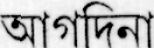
আগদিনা
